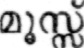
മൂസ്സ്
